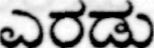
ಎರಡು
